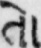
તો
